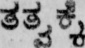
ತತ್ವಕ್ಕೆ
